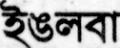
ইঙলবা
